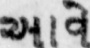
આવે
